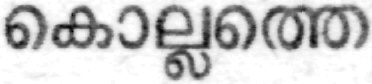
കൊല്ലത്തെ
